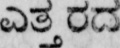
ಎತ್ತರದ
